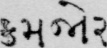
કમજોર
